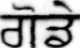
ਗੋਡੇ
